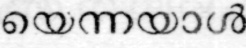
യെന്നയാള്‍
